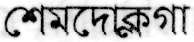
শেমদোক্লগা
